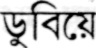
ডুবিয়ে
